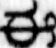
ಈ
